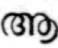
ആ
